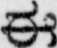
ಈ
